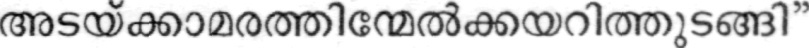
അടയ്ക്കാമരത്തിന്മേല്‍ക്കയറിത്തുടങ്ങി'”
